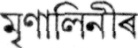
মৃণালিনীৰ
